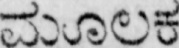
ಮೂಲಕ
